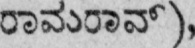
ರಾಮರಾವ್),
